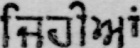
ਜਿਹੀਆਂ
